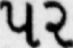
પર
